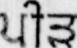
ਪੀੜ
